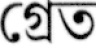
গ্রেত
